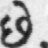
છે.
